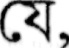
যে,
